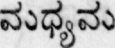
ಮಧ್ಯಮ
